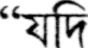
“যদি
